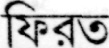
ফিরত
